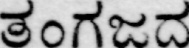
ತಂಗಜದ
